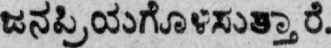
ಜನಪ್ರಿಯಗೊಳಿಸುತ್ತಾರೆ.
